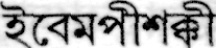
ইবেমপীশক্কী
